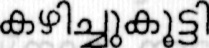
കഴിച്ചുകൂട്ടി
